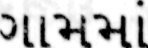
ગામમાં
